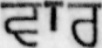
ਵਾਰ
